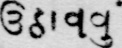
ઉઠાવવું
